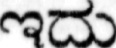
ಇದು
